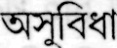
অসুবিধা
